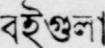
বইগুলা
